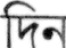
দিন
